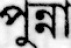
পুন্না
